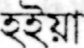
হইয়া
